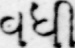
વધી
